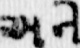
અને
